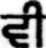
ਵੀ
